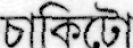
চাকিটো
